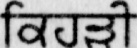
ਕਿਹੜੀ
